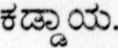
ಕಡ್ಡಾಯ.
